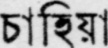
চাহিয়া
